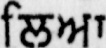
ਲਿਆ
